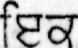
ਇਕ
